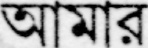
আমার
